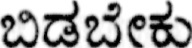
ಬಿಡಬೇಕು
